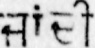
ਜਾਂਦੀ
